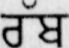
ਰੱਬ
